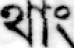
থাং
